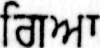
ਗਿਆ
